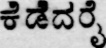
ಕೆಡೆದರೈ
